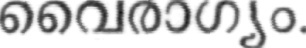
വൈരാഗ്യം.
